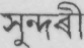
সুন্দৰী
